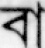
বা
